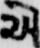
એ
